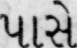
પાસે
